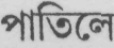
পাতিলে
